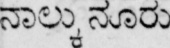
ನಾಲ್ಕುನೂರು
